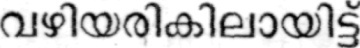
വഴിയരികിലായിട്ട്
